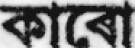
কাৰো
